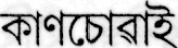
কাণচোৱাই
